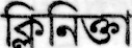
ক্লিনিক্তা
